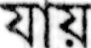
যায়
